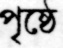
পৃষ্ঠে
